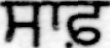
ਸਾਫ਼
